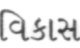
વિકાસ
